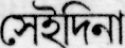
সেইদিনা
